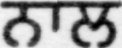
ਨਾਲ
